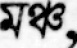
মঞ্চ,
